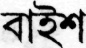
বাইশ
